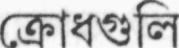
ক্রোধগুলি
